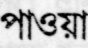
পাওয়া
